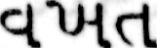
વખત
